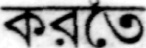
করতে
